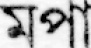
মপা
